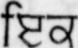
ਇਕ
